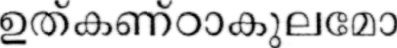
ഉത്കണ്ഠാകുലമോ
